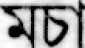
মচা
